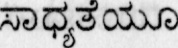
ಸಾಧ್ಯತೆಯೂ
